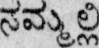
ನಮ್ಮಲ್ಲಿ
